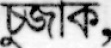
চুজাক,
